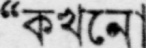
‘‘কখনো
